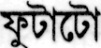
ফুটাটো
